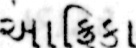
આફ્રિકા
